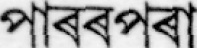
পাৰৰপৰা
